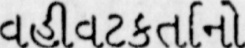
વહીવટકર્તાનો
